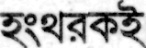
হংথরকই
